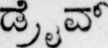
ಡ್ರೈವ್
